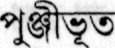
পুঞ্জীভূত
